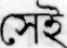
সেই
